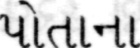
પોતાના
